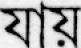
যায়
